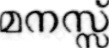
മനസ്സ്
